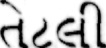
તેટલી
